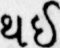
થઈ
